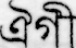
ঐগী
